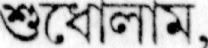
শুধোলাম,
